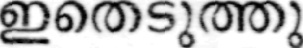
ഇതെടുത്തു
